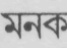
মনক
